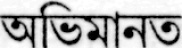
অভিমানত
